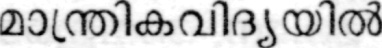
മാന്ത്രികവിദ്യയില്‍
